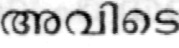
അവിടെ
